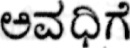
ಅವಧಿಗೆ
